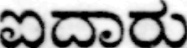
ಐದಾರು
